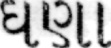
ઘણા
